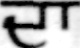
ਦਾ
